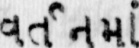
વર્તનમાં
